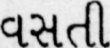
વસતી
